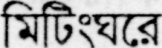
মিটিংঘরে
